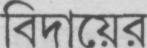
বিদায়ের
